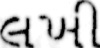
લખી
